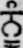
ਨੂੰ
